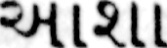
આશા
